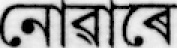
নোৱাৰে
